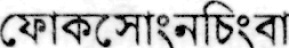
ফোকসোংনচিংবা
